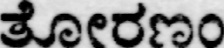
ತೋರಣ೦
